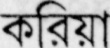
করিয়া
